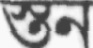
স্তন
